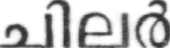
ചിലര്‍
